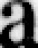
a
